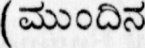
(ಮುಂದಿನ
